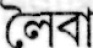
লৈবা
